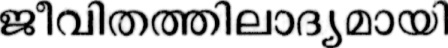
ജീവിതത്തിലാദ്യമായി
